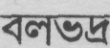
বলভদ্ৰ
